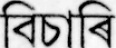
বিচাৰি
